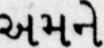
અમને
